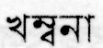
খম্বনা
